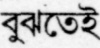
বুঝতেই
